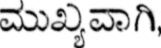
ಮುಖ್ಯವಾಗಿ,
